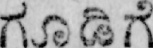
ಗೂಡಿಗೆ
